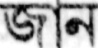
জান
